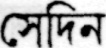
সেদিন
